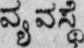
ವ್ಯವಸ್ಥೆ
